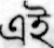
এই
